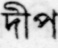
দীপ
